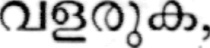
വളരുക,
